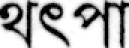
থৎপা
